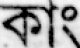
কাং
